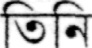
তিনি
